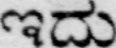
ಇದು
